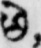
છે,
